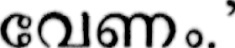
വേണം.’
